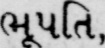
ભૂપતિ,
